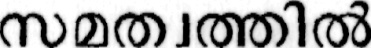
സമത്വത്തില്‍
